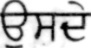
ਉਸਦੇ
